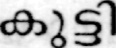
കുട്ടി
